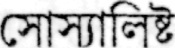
সোস্যালিষ্ট
